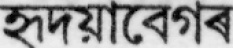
হৃদয়াবেগৰ
